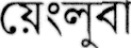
য়েংলুবা
